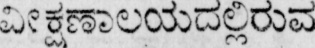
ವೀಕ್ಷಣಾಲಯದಲ್ಲಿರುವ
